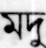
মদু
